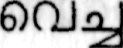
വെച്ച
